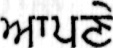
ਆਪਣੇ
